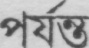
পর্যন্ত
